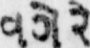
વગેરે
